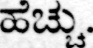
ಹೆಚ್ಚು.
